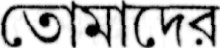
তোমাদের
